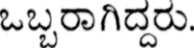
ಒಬ್ಬರಾಗಿದ್ದರು.
